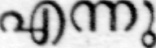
എന്നു
